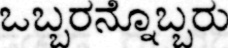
ಒಬ್ಬರನ್ನೊಬ್ಬರು
